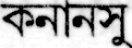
কনানসু
